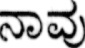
ನಾವು
